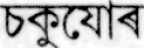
চকুযোৰ
